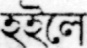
হইলে
